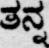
ತನ್ನ
